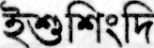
ইশুশিংদি
